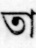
তা
